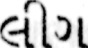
લીગ
